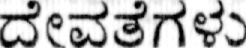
ದೇವತೆಗಳು
